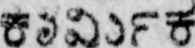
ಕಾರ್ಮಿಕ
